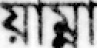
য়াম্না
